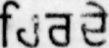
ਹਿਰਦੇ
